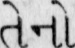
તેનો
